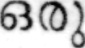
ഒരു
